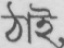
ঠাই,
